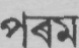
পৰম
